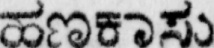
ಹಣಕಾಸು
